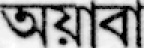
অয়াবা
